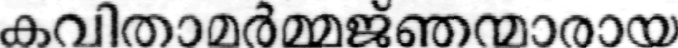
കവിതാമര്‍മ്മജ്ഞന്മാരായ
